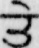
ਤੇ
